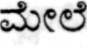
ಮೇಲೆ
